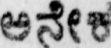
ಅನೇಕ
